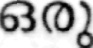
ഒരു
